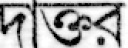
দাক্তর
